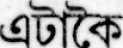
এটাকৈ
